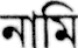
নামি
